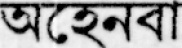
অহেনবা
